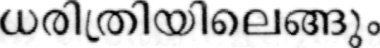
ധരിത്രിയിലെങ്ങും
